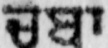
ਚਬਾ
